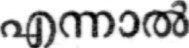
എന്നാല്‍
